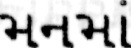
મનમાં
